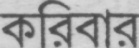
করিবার
